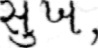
સુખ,
